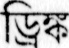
ড্রিঙ্ক
